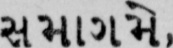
સમાગમે.
